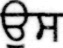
ਉਸ
